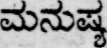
ಮನುಷ್ಯ
